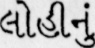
લોહીનું
